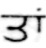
ਤਾਂ
